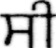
ਸੀ
